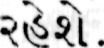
રહેશે.
